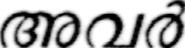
അവര്‍
